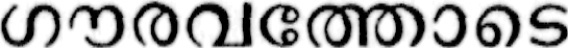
ഗൌരവത്തോടെ
